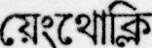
য়েংথোক্লি
